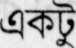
একটু
